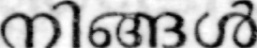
നിങ്ങള്‍
